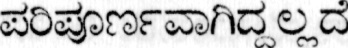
ಪರಿಪೂರ್ಣವಾಗಿದ್ದಲ್ಲದೆ
